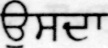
ਉਸਦਾ
